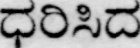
ಧರಿಸಿದ
